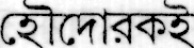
হৌদোরকই
